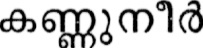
കണ്ണുനീര്‍
